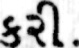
કરી.
